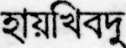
হায়খিবদু
